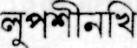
লুপশীনখি
